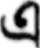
এ
